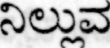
ನಿಲ್ಲುವ
